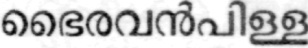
ഭൈരവന്‍പിള്ള
